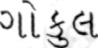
ગોકુલ
